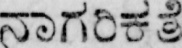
ನಾಗರಿಕತೆ
